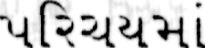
પરિચયમાં
